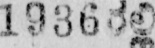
1936ರಲ್ಲಿ
